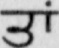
ਤਾਂ
